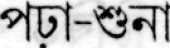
পঢ়া-শুনা
